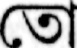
তো
